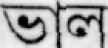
ভাল
